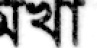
মখা
